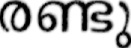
രണ്ടു
